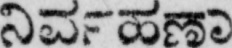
ನಿರ್ವಹಣಾ
